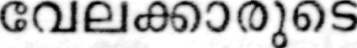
വേലക്കാരുടെ
